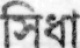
সিধা
